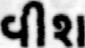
વીશ
